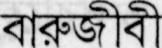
বারুজীবী
